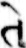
તે
